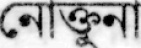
নোক্তুনা
